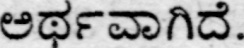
ಅರ್ಥವಾಗಿದೆ.
